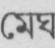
মেঘ
